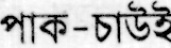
পাক-চাউই
